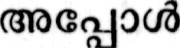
അപ്പോള്‍
